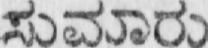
ಸುಮಾರು
